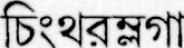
চিংথরম্লগা
